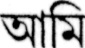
আমি
